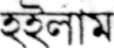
হইলাম
